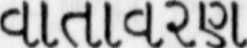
વાતાવરણ
